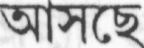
আসছে
